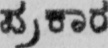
ಪ್ರಕಾರ
